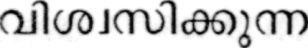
വിശ്വസിക്കുന്ന
